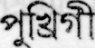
পুখ্রিগী
